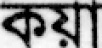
কয়া
